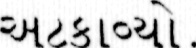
અટકાવ્યો.
